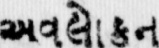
અવલોકન
